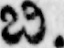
ಬಿ.
